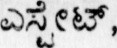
ಎಸ್ಟೇಟ್,
